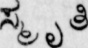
ಸ್ಮೃತಿ
